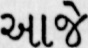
આજે
